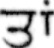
ਤਾਂ
